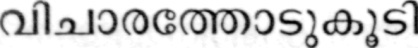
വിചാരത്തോടുകൂടി
